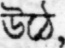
উঠে,
